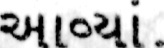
આવ્યાં.
